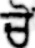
ਚੋਂ
